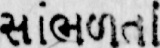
સાંભળતાં
